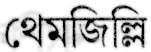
থেমজিল্লি
